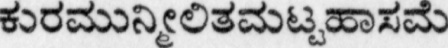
ಕುರಮುನ್ಮೀಲಿತಮಟ್ಟಹಾಸಮೆ
